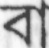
বা
